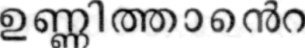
ഉണ്ണിത്താന്റെ
